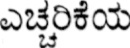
ಎಚ್ಚರಿಕೆಯ
